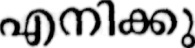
എനിക്കു
